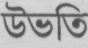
উভতি
